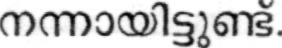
നന്നായിട്ടുണ്ട്.
